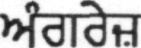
ਅੰਗਰੇਜ਼
